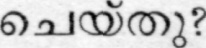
ചെയ്തു?
